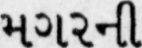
મગરની
